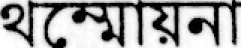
থম্মোয়না
